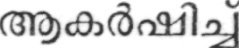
ആകര്‍ഷിച്ച്
